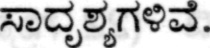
ಸಾದೃಶ್ಯಗಳಿವೆ.
